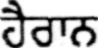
ਹੈਰਾਨ
